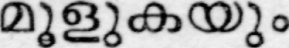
മൂളുകയും
